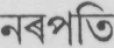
নৰপতি
